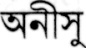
অনীসু
